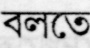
বলতে
